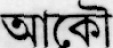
আকৌ
